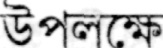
উপলক্ষে
